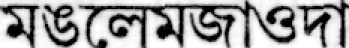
মঙলেমজাওদা
